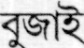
বুজাই
